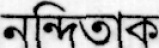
নন্দিতাক
